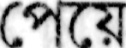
পেয়ে
